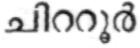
ചിററൂര്‍
